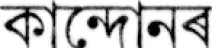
কান্দোনৰ
